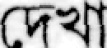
দেখা
